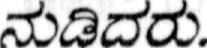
ನುಡಿದರು.
